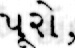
પરો.
